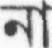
না
